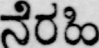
ನೆರಹಿ
